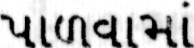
પાળવામાં
